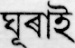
ঘূৰাই
